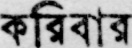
করিবার
